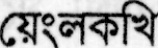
য়েংলকখি
